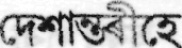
দেশান্তৰীহে
